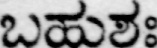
ಬಹುಶಃ
